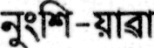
নুংশি-য়াৱা
